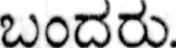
ಬಂದರು.
